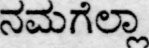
ನಮಗೆಲ್ಲಾ
